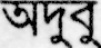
অদুবু
